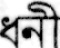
ধনী
